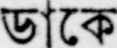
ডাকে
